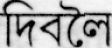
দিবলৈ
